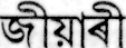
জীয়াৰী
